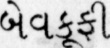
બેવકૂફી
